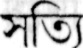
সত্যি
